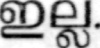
ഇല്ല.
